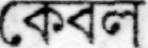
কেবল
